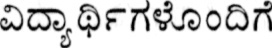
ವಿದ್ಯಾರ್ಥಿಗಳೊಂದಿಗೆ
